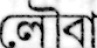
লৌবা
